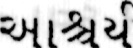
આશ્ચર્ય
